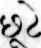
છૂટે
